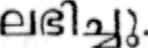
ലഭിച്ചു.
